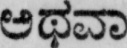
ಅಥವಾ
